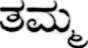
ತಮ್ಮ
